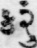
કરું
